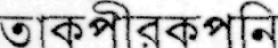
তাকপীরকপনি
